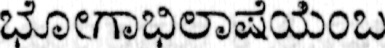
ಭೋಗಾಭಿಲಾಷೆಯೆಂಬ
